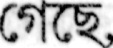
গেছে,
